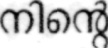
നിന്റെ
